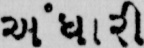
અંધારી
